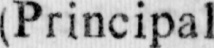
(Principal
